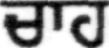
ਚਾਹ
